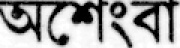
অশেংবা
